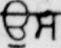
ਉਸ
